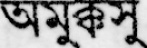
অমুক্কসু
